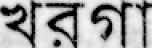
খরগা
